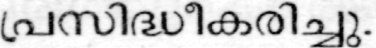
പ്രസിദ്ധീകരിച്ചു.
